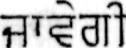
ਜਾਵੇਗੀ
